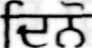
ਦਿਨੋ
